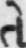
તે
